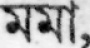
মমা,
